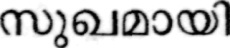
സുഖമായി
